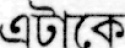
এটাকে
